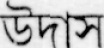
উদাস
